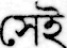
সেই
